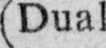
(Dual
